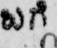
ಬಗ್ಗೆ
